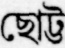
ছোট্ট
